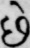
છે
